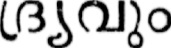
ദ്ര്യവും
